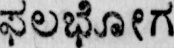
ಫಲಭೋಗ
